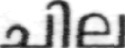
ചില
